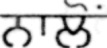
ਨਾਲੋਂ
